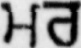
ਮਰ
